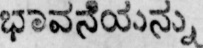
ಭಾವನೆಯನ್ನು
